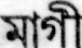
মাগী
